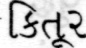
કિતૂર
